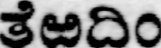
ತೆಱದಿಂ
